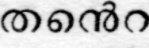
തന്റെ
